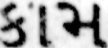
કામ
